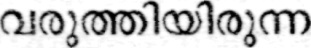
വരുത്തിയിരുന്ന
